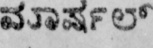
ಮಾರ್ಷಲ್
